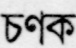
চণক
